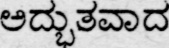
ಅದ್ಭುತವಾದ
